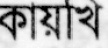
কায়খি
